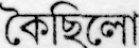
কৈছিলো
